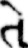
તે
